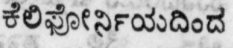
ಕೆಲಿಫೋರ್ನಿಯದಿಂದ
